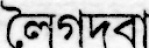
লৈগদবা
